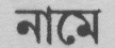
নামে
